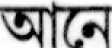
আনে
